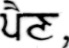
ਪੈਣ,
